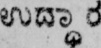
ಉದ್ಧಾರ
